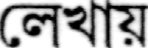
লেখায়
